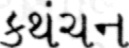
કથંચન
